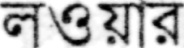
লওয়ার
